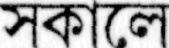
সকালে
